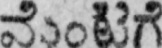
ಮೆಂಟಿಗೆ
